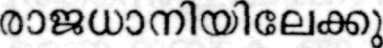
രാജധാനിയിലേക്കു
